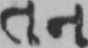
તન
